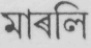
মাৰলি
